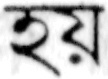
হয়
